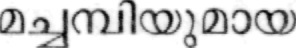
മച്ചമ്പിയുമായ
